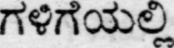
ಗಳಿಗೆಯಲ್ಲಿ
